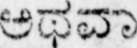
ಅಥವಾ
